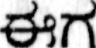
ಈಗ
